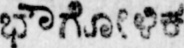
ಭೌಗೋಳಿಕ
